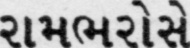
રામભરોસે
